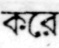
করে
